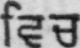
ਵਿਚ
